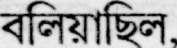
বলিয়াছিল,
